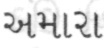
અમારા
